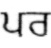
ਪਰ
